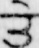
ਤੇ
